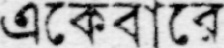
একেবারে
